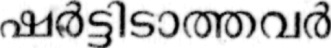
ഷര്‍ട്ടിടാത്തവര്‍
